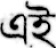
এই
